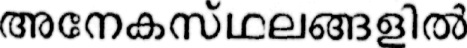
അനേകസ്ഥലങ്ങളില്‍
